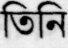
তিনি
